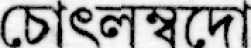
চোৎলম্বদো
